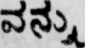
ವನ್ನು
